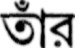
তাঁর
